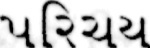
પરિચય
